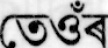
তেওঁৰ
